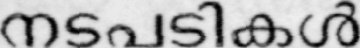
നടപടികള്‍
